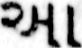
આ
